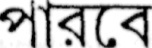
পারবে
